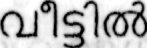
വീട്ടില്‍
